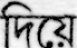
দিয়ে
